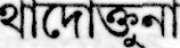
থাদোক্তুনা
